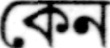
কেন
